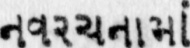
નવરચનામાં
